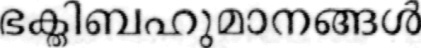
ഭക്തിബഹുമാനങ്ങള്‍
